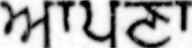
ਆਪਣਾ
